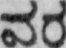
ವರ
